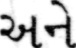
અને
